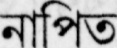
নাপিত
